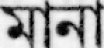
মানা
